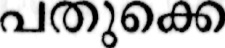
പതുക്കെ
